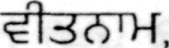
ਵੀਤਨਾਮ,
